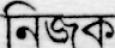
নিজক
